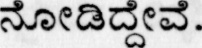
ನೋಡಿದ್ದೇವೆ.
